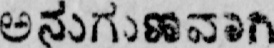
ಅನುಗುಣವಾಗಿ
